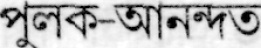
পুলক-আনন্দত
